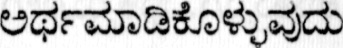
ಅರ್ಥಮಾಡಿಕೊಳ್ಳುವುದು
